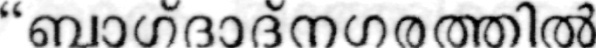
ബാഗ്‌ദാദ്ഗനഗരത്തിൽ
